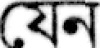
যেন
